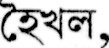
হৈখল,
